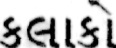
કલાકો
